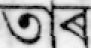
তাৰ
